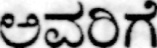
ಅವರಿಗೆ
